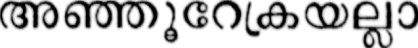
അഞ്ഞൂറേക്രയല്ലാ
